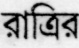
রাত্রির
